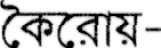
কৈরোয-
